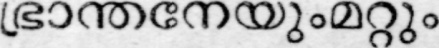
ഭ്രാന്തനേയുംമറ്റും
